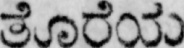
ತೊರೆಯ
